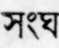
সংঘ
